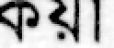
কয়া
